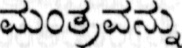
ಮಂತ್ರವನ್ನು
